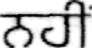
ਨਹੀਂ
